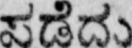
ಪಡೆದು
